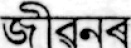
জীৱনৰ
